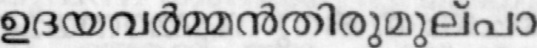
ഉദയവര്‍മ്മന്‍തിരുമുല്പാ
